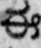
ಈ
